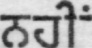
ਨਹੀਂ
